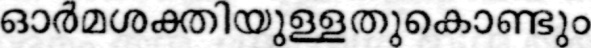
ഓര്‍മശക്തിയുള്ളതുകൊണ്ടും
